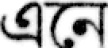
এনে
